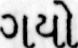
ગયો
